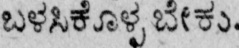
ಬಳಸಿಕೊಳ್ಳಬೇಕು.
